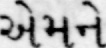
એમને
